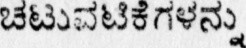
ಚಟುವಟಿಕೆಗಳನ್ನು
